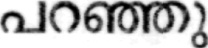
പറഞ്ഞു
